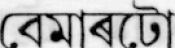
বেমাৰটো
